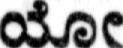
ಯೋ
